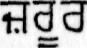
ਜ਼ਰੂਰ
